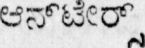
ಆನ್‌ಟೇರ್‍ಸ್
